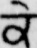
ਕੇ
